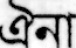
ঐনা
